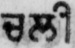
ਚਲੀ
